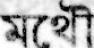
মথৌ
